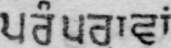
ਪਰੰਪਰਾਵਾਂ
